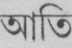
আতি
